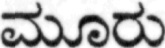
ಮೂರು
